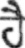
ਹੈ
